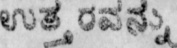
ಉತ್ತರವನ್ನು
